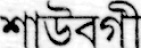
শাউবগী
